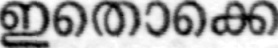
ഇതൊക്കെ
